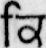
ਕਿ
